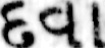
દવા
